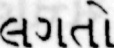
લગતો
